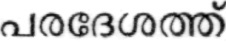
പരദേശത്ത്
